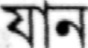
যান
